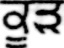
ਕੂੜ
